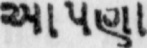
આપણા
